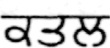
ਕਤਲ
